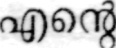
എന്റെ
